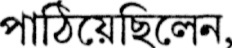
পাঠিয়েছিলেন,
